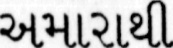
અમારાથી
